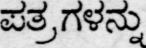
ಪತ್ರಗಳನ್ನು
